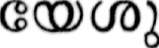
യേശു
